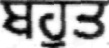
ਬਹੁਤ
